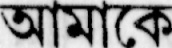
আমাকে
